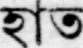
হাত
